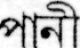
পানী
